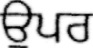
ਉਪਰ
